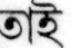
তাই
